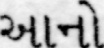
આનો
